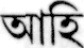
আহি
